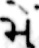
મેં
